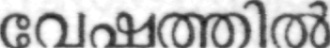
വേഷത്തില്‍
